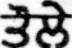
ਤੌਲੇ
